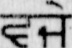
ਵਜੇ
